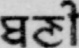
ਬਣੀ
